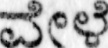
ವೇಳೆ
